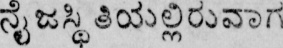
ನೈಜಸ್ಥಿತಿಯಲ್ಲಿರುವಾಗ
